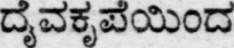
ದೈವಕೃಪೆಯಿಂದ
